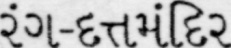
રંગ-દત્તમંદિર
